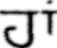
ਹਾਂ
